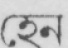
হেন
